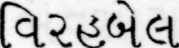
વિરહબેલ
